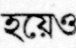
হয়েও
